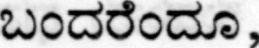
ಬಂದರೆಂದೂ,
